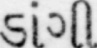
ડાંગી
